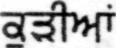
ਕੁੜੀਆਂ
